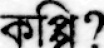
কপ্পি?
